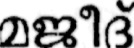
മജീദ്
